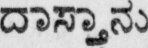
ದಾಸ್ತಾನು
